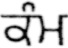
ਕੰਮ
